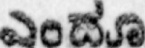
ಎಂದೂ
